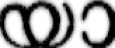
യാ
